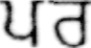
ਪਰ
